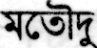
মতৌদু
